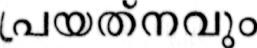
പ്രയത്നവും
